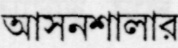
আসনশালার
